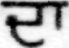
ਦਾ
